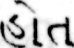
હોત
